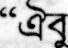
“ঐবু
